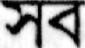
সব
